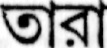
তারা
